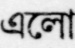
এলো
